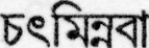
চৎমিন্নবা
